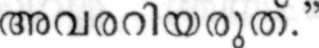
അവരറിയരുത്.”
